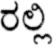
ರಲ್ಲಿ
